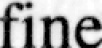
fine
